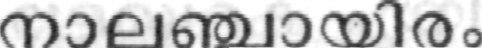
നാലഞ്ചായിരം
